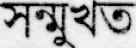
সন্মুখত
